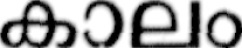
കാലം
